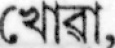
খোৱা,
